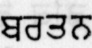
ਬਰਤਨ
